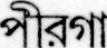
পীরগা
